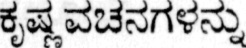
ಕೃಷ್ಣವಚನಗಳನ್ನು
